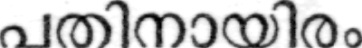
പതിനായിരം
